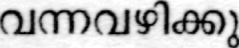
വന്നവഴിക്കു
